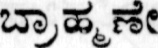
ಬ್ರಾಹ್ಮಣೇ
